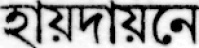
হায়দায়নে
